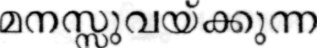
മനസ്സുവയ്ക്കുന്ന
